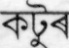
কটুৰ
